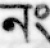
নং
